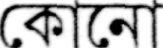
কোনো
